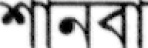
শানবা
